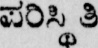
ಪರಿಸ್ಥಿತಿ
